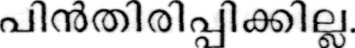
പിന്‍തിരിപ്പിക്കില്ല.
